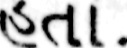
હતા.
